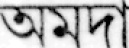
অমদা
